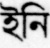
ইনি
